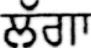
ਲੱਗਾ
